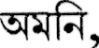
অমনি,
